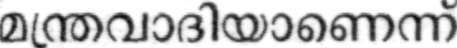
മന്ത്രവാദിയാണെന്ന്
